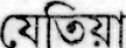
যেতিয়া
